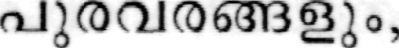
പുരവരങ്ങളും,
